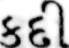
કદી
